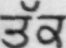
ਤੱਕ
